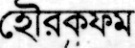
হৌরকফম
